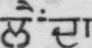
ਲੈਂਦਾ
